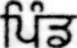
ਪਿੰਡ
